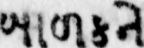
બાળકને
